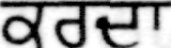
ਕਰਦਾ
